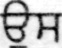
ਉਸ
